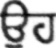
ਉਹ
